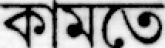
কামতে
